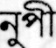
নুপী
